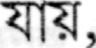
যায়,
